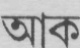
আক
